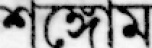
শঙ্গোম
